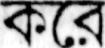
করে
